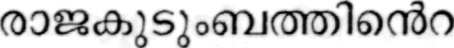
രാജകുടുംബത്തിന്റെ
